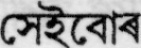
সেইবোৰ
